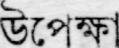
উপেক্ষা
